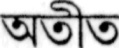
অতীত
